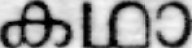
കഥാ
